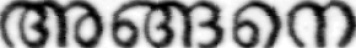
അങ്ങനെ
